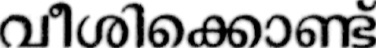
വീശിക്കൊണ്ട്
